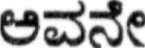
ಅವನೇ
